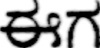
ಈಗ
